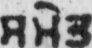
ਸਮੇਤ
